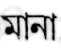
মানা
